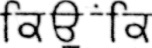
ਕਿਉਂਕਿ
